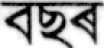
বছৰ
